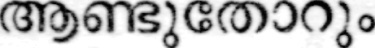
ആണ്ടുതോറും
